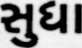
સુધા
